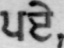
ਪਏ,
